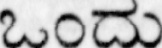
ಒಂದು
